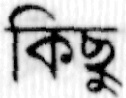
কিছু
